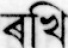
ৰখি
